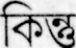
কিন্তু
